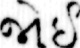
જોઈ
